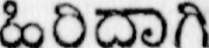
ಹಿರಿದಾಗಿ
